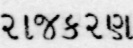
રાજકરણ
